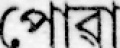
পোৱা
